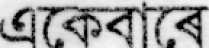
একেবাৰে
